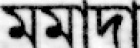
মমাদা
